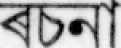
ৰচনা
